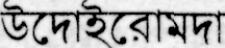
উদোইরোমদা
